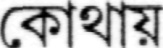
কোথায়
